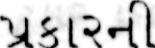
પ્રકારની
